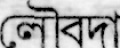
লৌবদা
